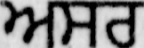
ਅਸਰ
